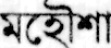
মহৌশা
